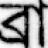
ব্রা
